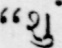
"શું
